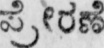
ಪ್ರೇರಣೆ
